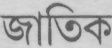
জাতিক
